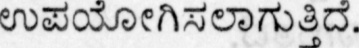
ಉಪಯೋಗಿಸಲಾಗುತ್ತಿದೆ.
